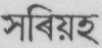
সৰিয়হ
